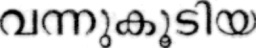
വന്നുകൂടിയ
